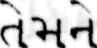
તેમને
